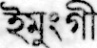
ইমুংগী
